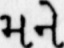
મને
